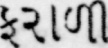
ફરાળી
